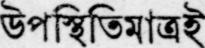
উপস্থিতিমাত্রই
